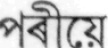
পৰীয়ে
